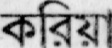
করিয়া
